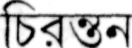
চিরন্তন
